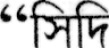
“সিদি
